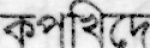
কপখিদে
